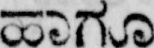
ಹಾಗೂ
